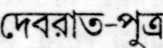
দেবরাত-পুত্র
